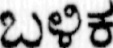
ಬಳಿಕ
